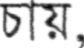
চায়,
